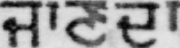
ਜਾਣਦਾ
